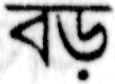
বড়
